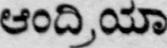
ಆಂದ್ರಿಯಾ
